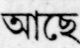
আছে
